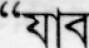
"যাব
